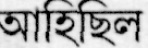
আহিছিল
